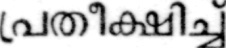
പ്രതീക്ഷിച്ച്
